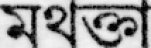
মথক্তা
